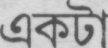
একটা
